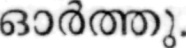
ഓര്‍ത്തു.
